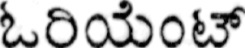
ಓರಿಯೆಂಟ್
